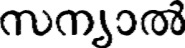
സന്യാല്‍
